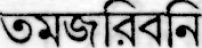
তমজরিবনি
